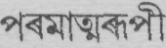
পৰমাত্মৰূপী
